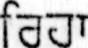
ਰਿਹਾ
